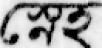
স্নেহ
